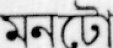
মনটো
